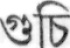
গুচি
